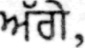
ਅੱਗੇ,
